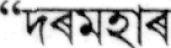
"দৰমহাৰ
